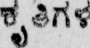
ಕೃತಿಗಳ
